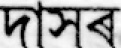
দাসৰ
